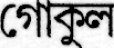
গোকুল
